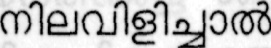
നിലവിളിച്ചാല്‍
